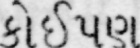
કોઈપણ
